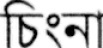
চিংনা
